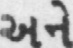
અને
